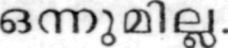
ഒന്നുമില്ല.
